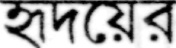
হৃদয়ের
